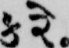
કરે.
